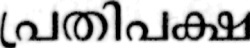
പ്രതിപക്ഷ
